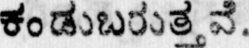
ಕಂಡುಬರುತ್ತವೆ.
